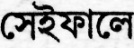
সেইফালে
